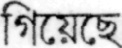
গিয়েছে
